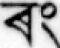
ৰং
